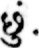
છું.
